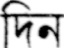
দিন
